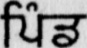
ਪਿੰਡ
